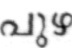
പുഴ
